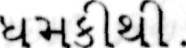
ધમકીથી.
